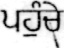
ਪਹੁੰਚੇ
